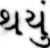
થયું
